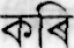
কৰি
